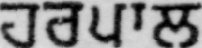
ਹਰਪਾਲ
